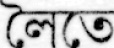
লৈতে
